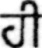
ਹੀ
